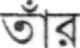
তাঁর
